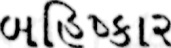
બહિષ્કાર
